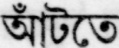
আঁটতে
